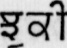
ਝੁਕੀ
